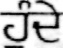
ਹੁੰਦੇ
